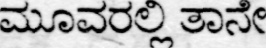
ಮೂವರಲ್ಲಿತಾನೇ
